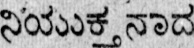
ನಿಯುಕ್ತನಾದ
